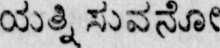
ಯತ್ನಿಸುವನೋ
